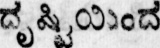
ದೃಷ್ಟಿಯಿಂದ
